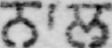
ਨਾਲ
